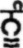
ਨੂੰ
